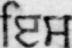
ਇਸ
